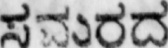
ಸಮರದ
